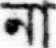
না
